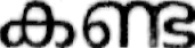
കണ്ട
